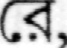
রে,
